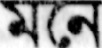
মনে
